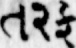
તરફ
